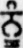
ਨੂੰ
